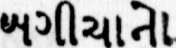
બગીચાનો
